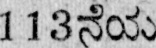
113ನೆಯ
